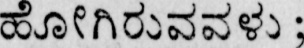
ಹೋಗಿರುವವಳು;
